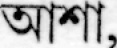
আশা,
